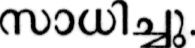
സാധിച്ചു.
